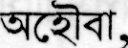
অহৌবা,
